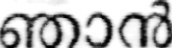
ഞാന്‍
